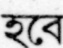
হবে
